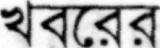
খবরের
